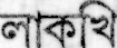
লাকখি
